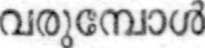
വരുമ്പോള്‍
